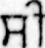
ਸੀ
